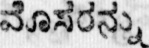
ಮೊಸರನ್ನು
